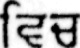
ਵਿਚ
